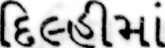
દિલ્હીમાં
